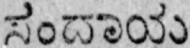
ಸಂದಾಯ
